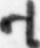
ન
